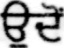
ਉਦੋਂ
